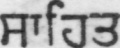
ਸਾਹਿਤ
